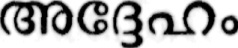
അദ്ദേഹം
